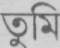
তুমি
